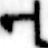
ન
